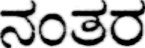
ನಂತರ
